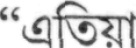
"এতিয়া
